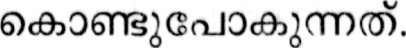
കൊണ്ടുപോകുന്നത്.
